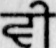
ਵੀ
